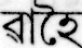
ৱাহৈ
